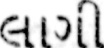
લાગી
